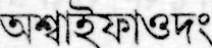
অশ্বাইফাওদং
